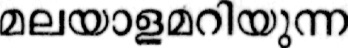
മലയാളമറിയുന്ന
